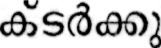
ക്ടര്‍ക്കു
